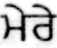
ਮੇਰੇ
